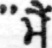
''ਮੈਂ
